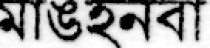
মাঙহনবা
